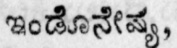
ಇಂಡೊನೇಷ್ಯ,
